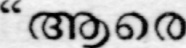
"ആരെ
